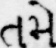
તમે
